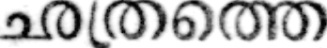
ഛത്രത്തെ
